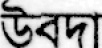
উবদা
